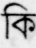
কি
